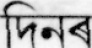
দিনৰ
